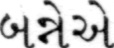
બન્નેએ
